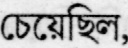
চেয়েছিল,
